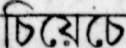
চিয়েচে
